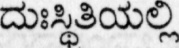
ದುಃಸ್ಥಿತಿಯಲ್ಲಿ
